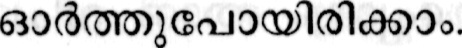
ഓര്‍ത്തുപോയിരിക്കാം.
